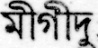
মীগীদু
